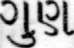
ગુણ
